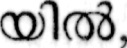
യില്‍,
